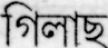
গিলাছ
